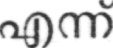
എന്ന്
